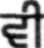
ਵੀ
